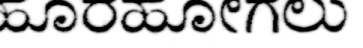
ಹೊರಹೋಗಲು
